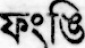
ফংঙি
